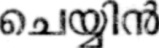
ചെയ്യിന്‍
